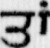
ਤਾਂ
